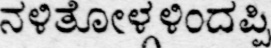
ನಳಿತೋಳ್ಗಳಿಂದಪ್ಪಿ
